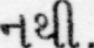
નથી.
